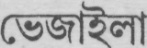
ভেজাইলা
